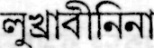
লুখ্রাবীনিনা
